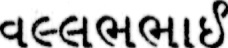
વલ્લભભાઈ
